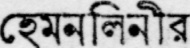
হেমনলিনীর
